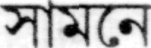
সামনে
